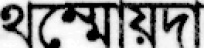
থম্মোয়দা
